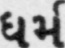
ધર્મ
